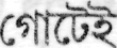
গোটেই
